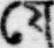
যে
